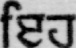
ਇਹ
